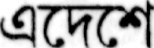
এদেশে
